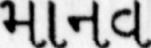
માનવ
